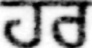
ਹਰ
